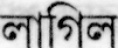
লাগিল
